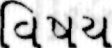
વિષય
